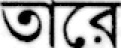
তারে
